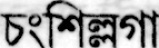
চংশিল্লগা
